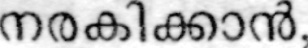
നരകിക്കാന്‍,
